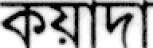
কয়াদা
